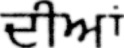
ਦੀਆਂ
